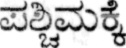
ಪಶ್ಚಿಮಕ್ಕೆ
